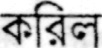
করিল
